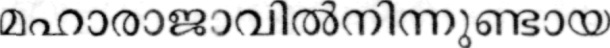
മഹാരാജാവില്‍നിന്നുണ്ടായ
